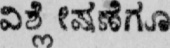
ವಿಶ್ಲೇಷಣೆಗೂ
